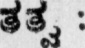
ತತ್ವ:
